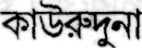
কাউরদুনা
